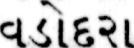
વડોદરા
